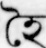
হৈ
